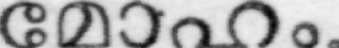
മോഹം.
